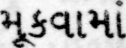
મૂકવામા
